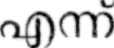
എന്ന്
